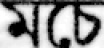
মচে
